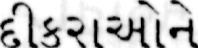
દીકરાઓને
